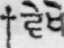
ਵੇਖੋ
